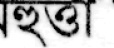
মহুত্তা
